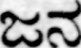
ಜನ
